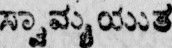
ಸ್ವಾಮ್ಯಯುತ
